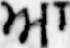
ਆ
